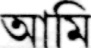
আমি
